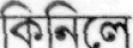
কিনিলে
